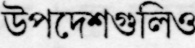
উপদেশগুলিও
